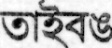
তাইবঙ
